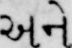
અને
